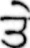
ਤੇ
